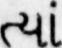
ત્યાં
